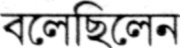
বলেছিলেন
